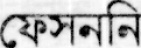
ফেসননি
